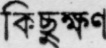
কিছুক্ষণ
